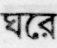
ঘরে
